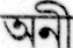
অনী
